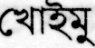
খোইমু
